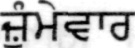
ਜ਼ੁੰਮੇਵਾਰ
